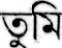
তুমি
